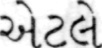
એટલે
